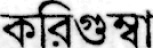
করিগুম্বা
